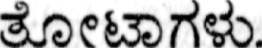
ತೋಟಾಗಳು.
